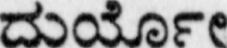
ದುರ್ಯೋ
